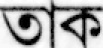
তাক
